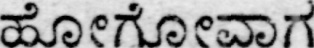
ಹೋಗೋವಾಗ
